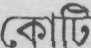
কোটি
